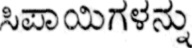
ಸಿಪಾಯಿಗಳನ್ನು
